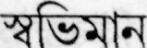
স্বভিমান
